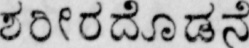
ಶರೀರದೊಡನೆ
